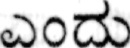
ಎಂದು
